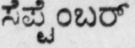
ಸೆಪ್ಟೆಂಬರ್
